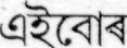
এইবোৰ
